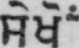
ਸੇਖੋਂ
